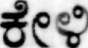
ಕೇಳಿ
